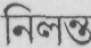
নিলন্ত
